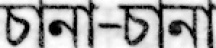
চানা-চানা
